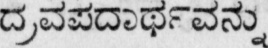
ದ್ರವಪದಾರ್ಥವನ್ನು
